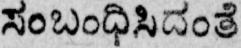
ಸಂಬಂಧಿಸಿದಂತೆ
